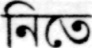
নিতে
